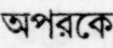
অপরকে
